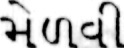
મેળવી
